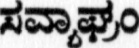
ಸವ್ಯಾಘ್ರಂ
